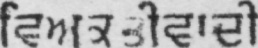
ਵਿਅਕਤੀਵਾਦੀ
